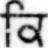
ਕਿ
